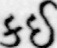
કઈ
